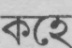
কহে
